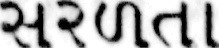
સરળતા
